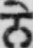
ਨੇ
